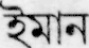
ইমান
